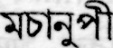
মচানুপী
